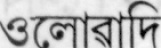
ওলোৱাদি
